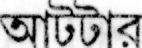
আটটার
